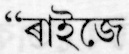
"ৰাইজে
